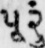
પૂરું
